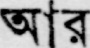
আর
